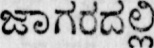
ಜಾಗರದಲ್ಲಿ
